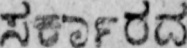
ಸರ್ಕಾರದ
